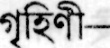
গৃহিণী-
